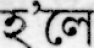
হ'লে
